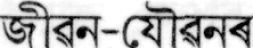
জীৱন-যৌৱনৰ
